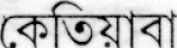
কেতিয়াবা
